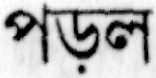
পড়ল
